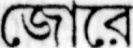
জোরে
